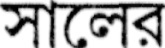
সালের
